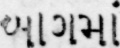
બાગમાં
